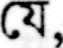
যে,
